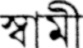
স্বামী
